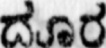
ದೂರ
